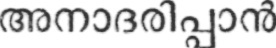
അനാദരിപ്പാന്‍
